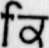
ਕਿ
